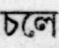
চলে
